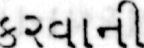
કરવાની
